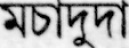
মচাদুদা
